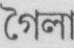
গৈলা
